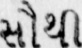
સૌથી
